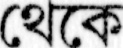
থেকে
